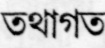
তথাগত
